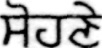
ਸੋਹਣੇ
